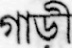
গাড়ী
